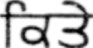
ਕਿਤੇ
